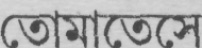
তোমাতেসে
